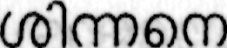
ശിന്നനെ
